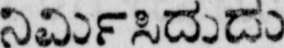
ನಿರ್ಮಿಸಿದುದು
